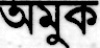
অমুক
